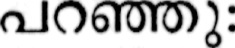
പറഞ്ഞു:
